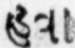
હવા.
